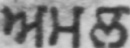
ਅਮਲ
